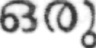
ഒരു
